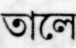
তালে
